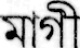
মাগী
